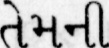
તેમની
